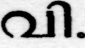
വി.
